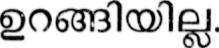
ഉറങ്ങിയില്ല.
